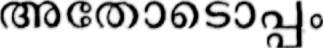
അതോടൊപ്പം
